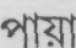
পায়া
